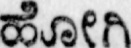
ಹೋಗಿ
